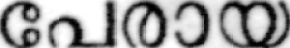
പേരായ
